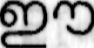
ഈ
